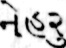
નેહરુ
